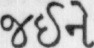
જઈને
